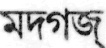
মদগজ্
